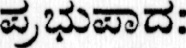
ಪ್ರಭುಪಾದ:
